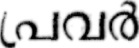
പ്രവര്‍
